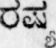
ರಷ್ಯ
